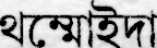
থম্মোইদা
